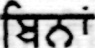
ਬਿਨਾਂ
